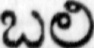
ಬಲಿ
